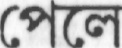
পেলে
